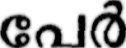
പേര്‍
